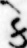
કે
